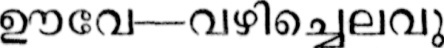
ഊവേ-വഴിച്ചെലവു
